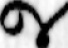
જ
